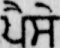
ਪੈਸੇ
